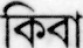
কিবা
